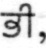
ਭੀ,
